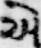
સ્ત્રીઓનો
